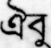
ঐবু
